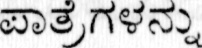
ಪಾತ್ರೆಗಳನ್ನು
